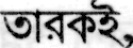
তারকই,
